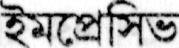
ইমপ্রেসিভ
